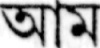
আম
